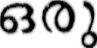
ഒരു
